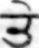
ਤੇ
